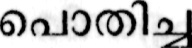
പൊതിച്ച
